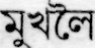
মুখলৈ
